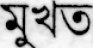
মুখত
